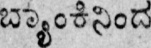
ಬ್ಯಾಂಕಿನಿಂದ
